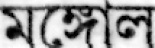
মঙ্গোল
